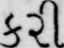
કરી
